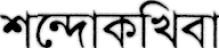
শন্দোকখিবা
